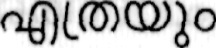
എത്രയും
